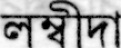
লম্বীদা
